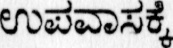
ಉಪವಾಸಕ್ಕೆ
